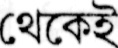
থেকেই
